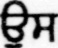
ਉਸ
